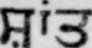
ਸ਼ਾਂਤ
